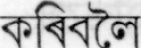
কৰিবলৈ
